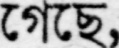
গেছে,
